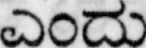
ಎಂದು
